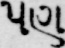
પણ
